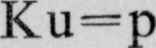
Ku=p
